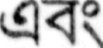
এবং
